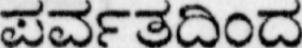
ಪರ್ವತದಿಂದ
